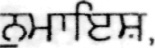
ਨੁਮਾਇਸ਼,
